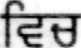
ਵਿਚ
